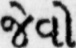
જેવો
